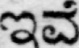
ಇವೆ
